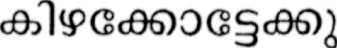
കിഴക്കോട്ടേക്കു
